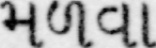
મળવા
